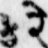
કરે
